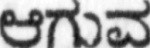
ಆಗುವ
